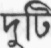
দুটি
